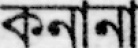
কনানা
